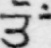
ਤੋਂ
